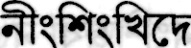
নীংশিংখিদে
